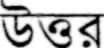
উত্তর
